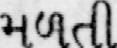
મળતી
